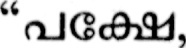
“പക്ഷേ,
